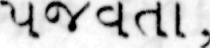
પજવતા,
